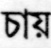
চায়
